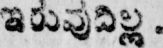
ಇರುವುದಿಲ್ಲ.
